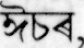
ঈচৰ,
